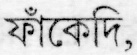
ফাঁকেদি,
